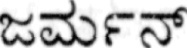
ಜರ್ಮನ್
